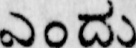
ಎಂದು
